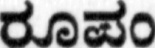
ರೂಪಂ
